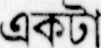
একটা
